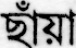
ছাঁয়া
